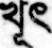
খূৎ
